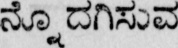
ನ್ನೊದಗಿಸುವ
